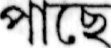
পাছে
